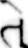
તે
